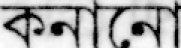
কনানো
